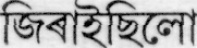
জিৰাইছিলো
